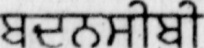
ਬਦਨਸੀਬੀ
